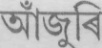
আঁজুৰি
